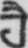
ਹੈ
